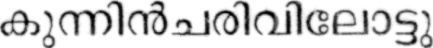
കുന്നിന്‍ചരിവിലോട്ടു
